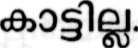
കാട്ടില്ല.
